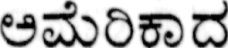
ಅಮೆರಿಕಾದ
